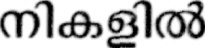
നികളില്‍
